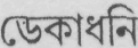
ডেকাধনি
